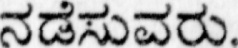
ನಡೆಸುವರು,
